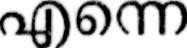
എന്നെ
